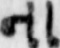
ના
